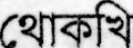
থোকখি
